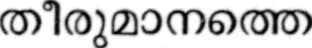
തീരുമാനത്തെ
